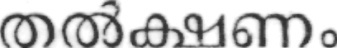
തല്‍ക്ഷണം
